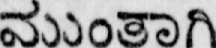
ಮುಂತಾಗಿ
